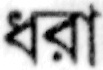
ধরা
